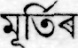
মূর্তিৰ
